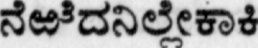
ನೆಱೆದನಿಲ್ಲೇಕಾಕಿ
